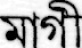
মাগী
